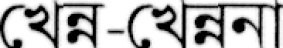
খেন্ন-খেন্ননা
